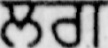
ਲਗ
